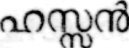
ഹസ്സന്‍
